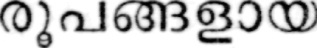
രൂപങ്ങളായ
